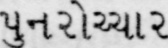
પુનરોચ્ચાર
